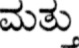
ಮತ್ತು
